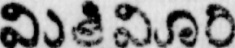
ಮಿತಿಮೀರಿ
